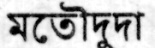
মতৌদুদা
